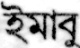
ইমাবু
